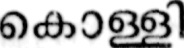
കൊള്ളി
